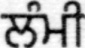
ਲੰਮੀ
